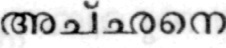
അച്ഛനെ
